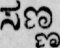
ಸಣ್ಣ
